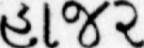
હાજર
